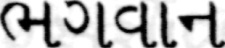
ભગવાન
